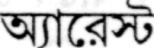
অ্যারেস্ট
